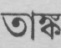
তাঙ্ক
